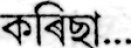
কৰিছা...
